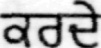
ਕਰਦੇ
